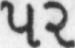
પર
